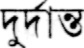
দুর্দান্ত
